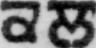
ਕਲ
